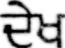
ਦੇਖ
